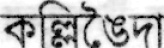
কল্লিঙৈদা
